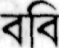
ববি
